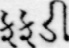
ફફડી
